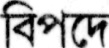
বিপদে
